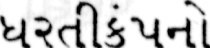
ધરતીકંપનો
